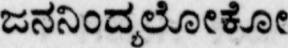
ಜನನಿಂದ್ಯಲೋಕೋ
